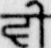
ਵੀ
